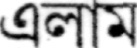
এলাম
